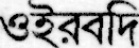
ওইরবদি
